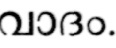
വാദം.
